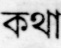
কথা
